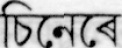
চিনেৰে
